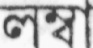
লম্বা
